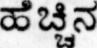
ಹೆಚ್ಚಿನ
